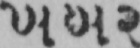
ખબર
